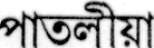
পাতলীয়া
